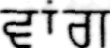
ਵਾਂਗ
